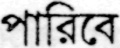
পারিবে
